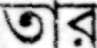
তার
